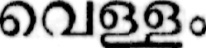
വെള്ളം
